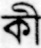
কী
